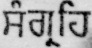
ਸੰਗ੍ਰਹਿ
